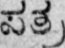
ಪತ್ರ
